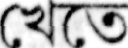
খেতে
